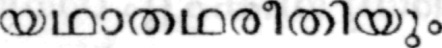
യഥാതഥരീതിയും
